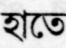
হাতে
